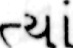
ત્યાં
